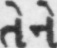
તેને
